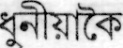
ধুনীয়াকৈ
